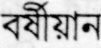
বর্ষীয়ান
